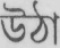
উঠা
